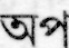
অপ
